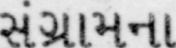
સંગ્રામના
